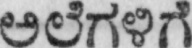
ಅಲೆಗಳಿಗೆ
